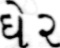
ઘેર
